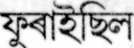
ফুৰাইছিল
